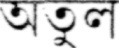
অতুল
